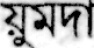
য়ুমদা
